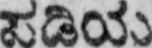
ಪಡಿಯ
